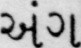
અંગ
